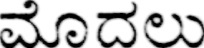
ಮೊದಲು
